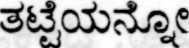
ತಟ್ಟೆಯನ್ನೋ
